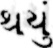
થયું
